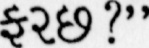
ફરછ?"
